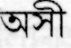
অসী
